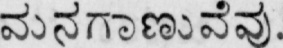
ಮನಗಾಣುವೆವು.
